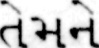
તેમને
